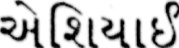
એશિયાઈ
